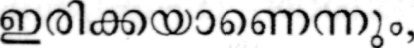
ഇരിക്കയാണെന്നും,
